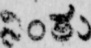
ನಿಂತು
